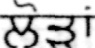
ਲੋੜਾਂ
